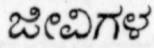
ಜೀವಿಗಳ
